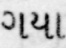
ગયા
